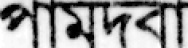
পামদবা
